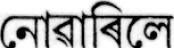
নোৱাৰিলে
